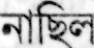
নাছিল
